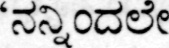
‘ನನ್ನಿಂದಲೇ
